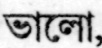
ভালো,
